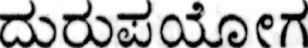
ದುರುಪಯೋಗ
